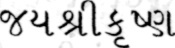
જયશ્રીકૃષ્ણ
